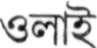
ওলাই
